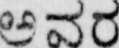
ಅವರ
